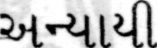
અન્યાયી
